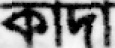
কাদা
